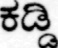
ಕಡ್ಡಿ
